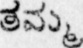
ತಮ್ಮ
